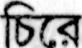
চিরে
